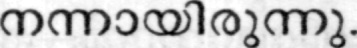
നന്നായിരുന്നു.
